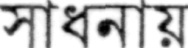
সাধনায়
